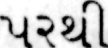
પરથી
